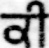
ਕੀ
